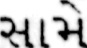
સામે
